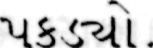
પકડયો.
